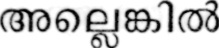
അല്ലെങ്കില്‍
